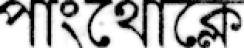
পাংথোক্লে
